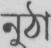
নুঠা
